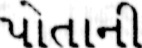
પોતાની
